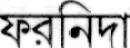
ফরনিদা
